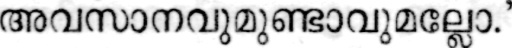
അവസാനവുമുണ്ടാവുമല്ലോ.’
